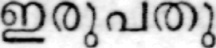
ഇരുപതു
